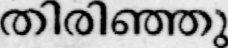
തിരിഞ്ഞു
